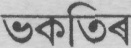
ভকতিৰ
